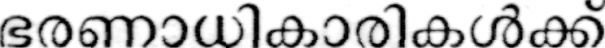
ഭരണാധികാരികള്‍ക്ക്
